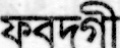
ফবদগী
